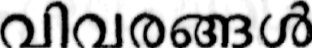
വിവരങ്ങള്‍
